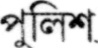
পুলিশ
